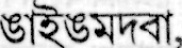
ঙাইঙমদবা,
